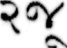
રજૂ
